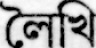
লৈখি
